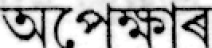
অপেক্ষাৰ
